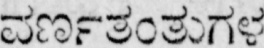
ವರ್ಣತಂತುಗಳ
